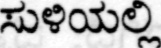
ಸುಳಿಯಲ್ಲಿ
